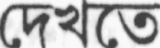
দেখতে
